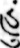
હું
